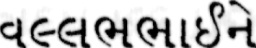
વલ્લભભાઈને
